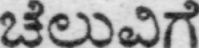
ಚೆಲುವಿಗೆ
